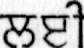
ਲਈ
